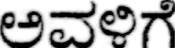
ಅವಳಿಗೆ
